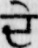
ਦੇ
